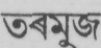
তৰমুজ
